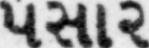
પસાર
